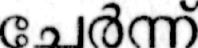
ചേര്‍ന്ന്
